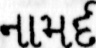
નામર્દ
